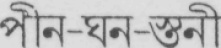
পীন-ঘন-স্তনী
